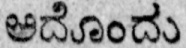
ಅದೊಂದು
